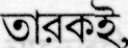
তারকই,
